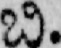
ಬಿ.
